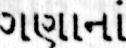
ગણાનાં
